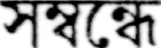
সম্বন্ধে
